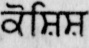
ਕੋਸ਼ਿਸ਼
